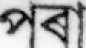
পৰা
